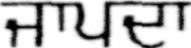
ਜਾਪਦਾ
